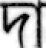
দা
